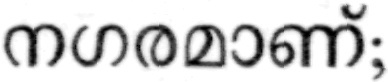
നഗരമാണ്,
